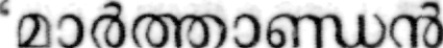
'മാര്‍ത്താണ്ഡന്‍
